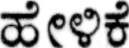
ಹೇಳಿಕೆ
